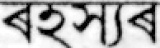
ৰহস্যৰ
